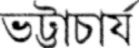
ভট্টাচার্য
